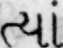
ત્યાં
